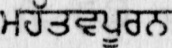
ਮਹੱਤਵਪੂਰਨ
